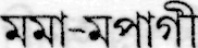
মমা-মপাগী
